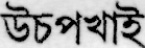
উচপখাই
